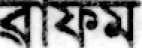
ৱাফম
